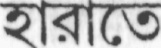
হারাতে
